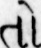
તો
